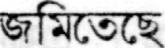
জমিতেছে
